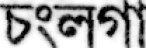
চংলগা
